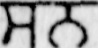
ਸਨ
